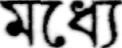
মধ্যে
